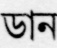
ডান
